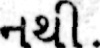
નથી.
